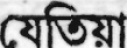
যেতিয়া
